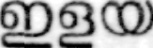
ഇളയ
